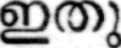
ഇതു
